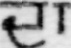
ਦਾ
